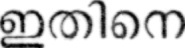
ഇതിനെ
